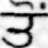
ਤੋਂ
